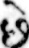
છે
